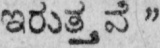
ಇರುತ್ತವೆ”
